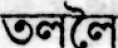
তললৈ
